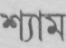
শ্যাম
